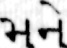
મને
